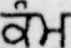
ਕੰਮ
